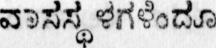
ವಾಸಸ್ಥಳಗಳೆಂದೂ
